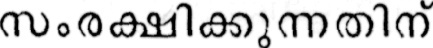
സംരക്ഷിക്കുന്നതിന്
